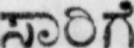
ಸಾರಿಗೆ
